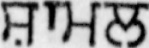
ਸ਼ਾਮਲ
